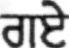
ਗਏ
